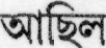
আছিল
